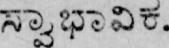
ಸ್ವಾಭಾವಿಕ.
